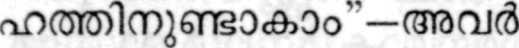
ഹത്തിനുണ്ടാകാം”-അവര്‍
